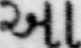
આ
